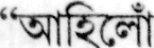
"আহিলোঁ
